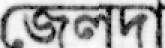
জেলদা
